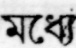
মধ্যে
